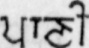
ਪਾਣੀ
